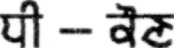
ਧੀ-ਕੌਣ
